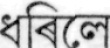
ধৰিলে
